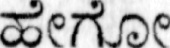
ಹೇಗೋ
